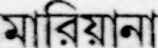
মারিয়ানা
